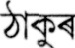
ঠাকুৰ
